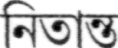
নিতান্ত
